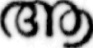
ആ
